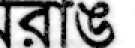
মরাঙ
